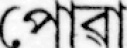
পোৱা
